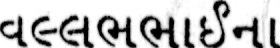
વલ્લભભાઈના
